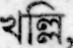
খল্লি,
